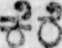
ಕೆರೆ
